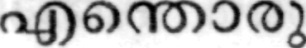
എന്തൊരു
